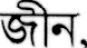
জীন,
